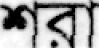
শরা
